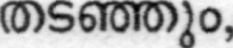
തടഞ്ഞും,
